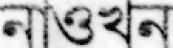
নাওখন
